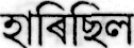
হাৰিছিল
